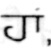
ਹਾਂ,
